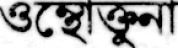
ওন্থোক্তুনা
